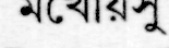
“মখোয়সু
